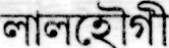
লালহৌগী
